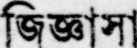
জিজ্ঞাসা
